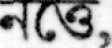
নত্তে,
